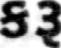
કરૂ
